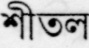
শীতল
